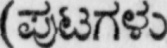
(ಪುಟಗಳು
